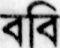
ববি
